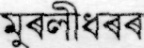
মুৰলীধৰৰ
